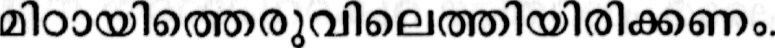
മിഠായിത്തെരുവിലെത്തിയിരിക്കണം.
